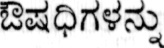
ಔಷಧಿಗಳನ್ನು
